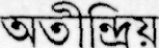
অতীন্দ্রিয়
